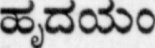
ಹೃದಯಂ
